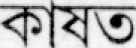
কাষত
